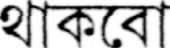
থাকবো
